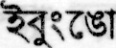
ইবুংঙো
